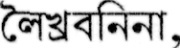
লৈখ্রবনিনা,
